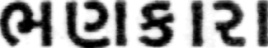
ભણકારા
